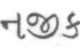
નજીક
